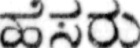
ಹೆಸರು
